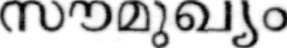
സൌമുഖ്യം
